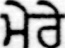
ਮੇਰੇ
